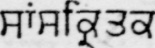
ਸਾਂਸਕ੍ਰਿਤਕ
